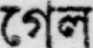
গেল
